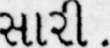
સારી.
